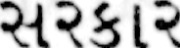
સરકાર
